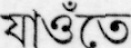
যাওঁতে
